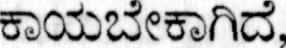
ಕಾಯಬೇಕಾಗಿದೆ,
